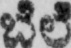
ಬೆಲೆ
